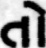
તો
